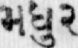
મધુર
